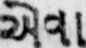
એવા
